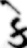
કે
